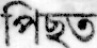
পিছত
